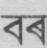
বৰ
